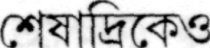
শেষাদ্রিকেও
